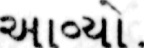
આવ્યો.
